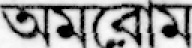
অমরোম
